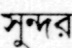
সুন্দর
